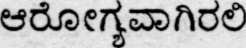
ಆರೋಗ್ಯವಾಗಿರಲಿ
